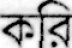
করি
